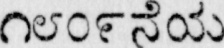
೧೮೦೯ನೆಯ
